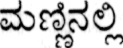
ಮಣ್ಣಿನಲ್ಲಿ
